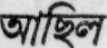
আছিল
